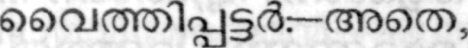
വൈത്തിപ്പട്ടര്‍:-അതെ,
